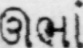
ઊભાં
